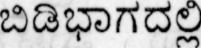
ಬಿಡಿಭಾಗದಲ್ಲಿ
